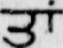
ਤਾਂ
